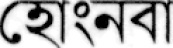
হোংনবা
